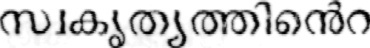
സ്വകൃത്യത്തിന്റെ
